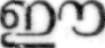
ഈ
